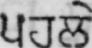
ਪਹਲੇ
